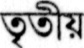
তৃতীয়
